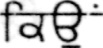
ਕਿਉਂ
